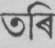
তৰি
